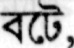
বটে,
